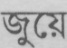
জুয়ে
